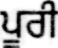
ਪੂਰੀ
